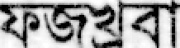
ফজখ্রবা
